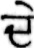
ਦੇ
